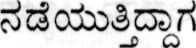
ನಡೆಯುತ್ತಿದ್ದಾಗ
